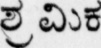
ಶ್ರಮಿಕ
